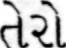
તેરો
